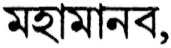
মহামানব,
